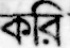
করি
